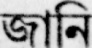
জানি
